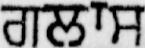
ਗਲਾਸ
